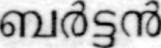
ബര്‍ട്ടന്‍
